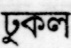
ঢুকল
